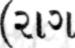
(રાગ
